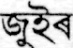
জুইৰ
